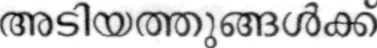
അടിയത്തുങ്ങള്‍ക്ക്
